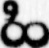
ಹಿ
